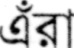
এঁরা
